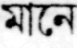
মানে
